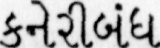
કનેરીબંધ
